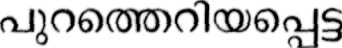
പുറത്തെറിയപ്പെട്ട
